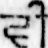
ਵੀ
